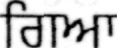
ਗਿਆ
